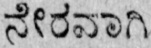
ನೇರವಾಗಿ
